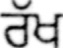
ਰੱਖ
